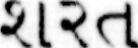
શરત
